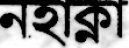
নহাক্না
